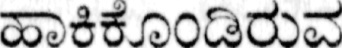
ಹಾಕಿಕೊಂಡಿರುವ
